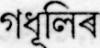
গধূলিৰ
